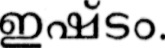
ഇഷ്ടം.
